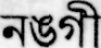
নঙঘী
